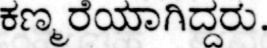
ಕಣ್ಮರೆಯಾಗಿದ್ದರು.
